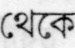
থেকে
